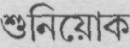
শুনিয়োক
